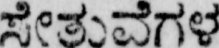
ಸೇತುವೆಗಳ
